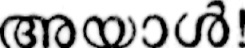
അയാള്‍!
